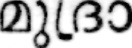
മുദ്രാ
